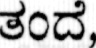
ತಂದೆ,
